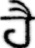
ਹੈ
